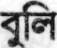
বুলি
